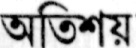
অতিশয়
